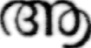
ആ
